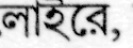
লোইরে,
